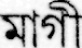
মাগী
